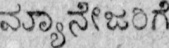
ಮ್ಯಾನೇಜರಿಗೆ
